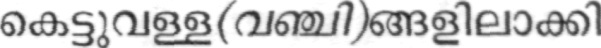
കെട്ടുവള്ള(വഞ്ചി)ങ്ങളിലാക്കി
